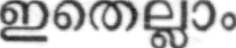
ഇതെല്ലാം
